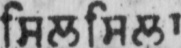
ਸਿਲਸਿਲਾ
